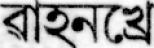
ৱাহনখ্রে
